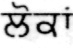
ਲੋਕਾਂ
